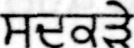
ਸਦਕੜੇ
